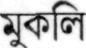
মুকলি
